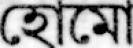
হোমো
